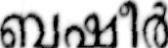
ബഷീര്‍
